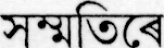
সন্মতিৰে
